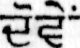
ਦੋਵੇਂ
